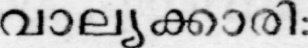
വാല്യക്കാരി:
